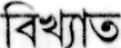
বিখ্যাত
